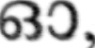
ഓ,
